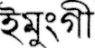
ইমুংগী
